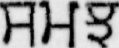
ਸਮਝ
